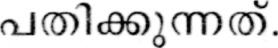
പതിക്കുന്നത്.
